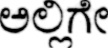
ಅಲ್ಲಿಗೇ
